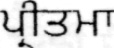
ਪ੍ਰੀਤਮਾ
